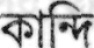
কান্দি
